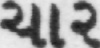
ચાર
